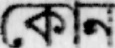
কোন
